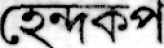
হেন্দকপ
